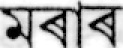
মৰাৰ
